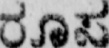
ರೂಪ
